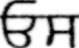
ਓਸ
